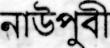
নাউপুবী
